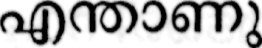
എന്താണു
